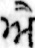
ਐ
